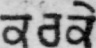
ਕਰਕੇ
